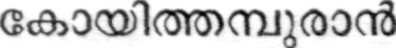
കോയിത്തമ്പുരാന്‍
